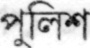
পুলিশ
